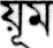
য়ূম
